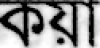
কয়া
